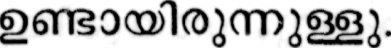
ഉണ്ടായിരുന്നുള്ളു.
